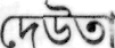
দেউতা
